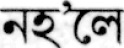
নহ'লে
